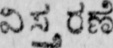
ವಿಸ್ತರಣೆ
